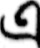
এ
